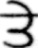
ਤੇ
